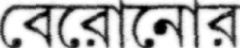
বেরোনোর
